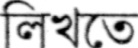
লিখতে
